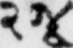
રજૂ
